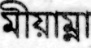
মীয়াম্না
